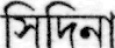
সিদিনা
